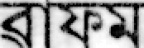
ৱাফম
